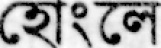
হোংলে
